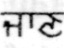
ਜਾਣ
